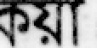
কয়া
